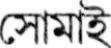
সোমাই
